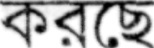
করছে
